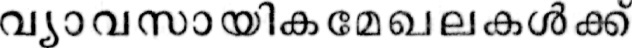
വ്യാവസായികമേഖലകള്‍ക്ക്
